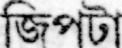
জিপটা
